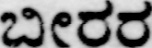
ಬೀರರ
